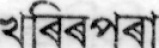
খৰিৰপৰা
